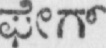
ಫೇಗ್
